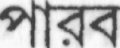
পারব
